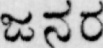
ಜನರ
